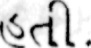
હતી.
